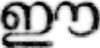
ഈ
